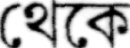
থেকে
